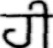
ਹੀ
